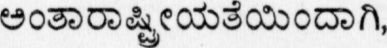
ಅಂತಾರಾಷ್ಟ್ರೀಯತೆಯಿಂದಾಗಿ,
